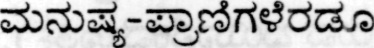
ಮನುಷ್ಯ-ಪ್ರಾಣಿಗಳೆರಡೂ
